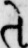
તે
